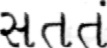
સતતં
